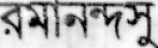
রমানন্দসু
